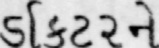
ર્ડાકટરને
